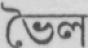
ভৈল
